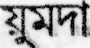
য়ুমদা
